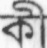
কী
